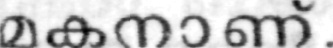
മകനാണ്.
